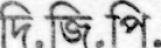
দি.জি.পি.
